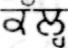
ਕੱਲ੍ਹ
